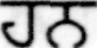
ਹਨ
